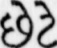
છેટે
